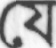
যে
